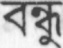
বন্ধু
